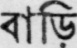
বাড়ি
